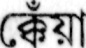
ক্কেঁয়া
